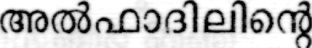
അല്‍ഫാദിലിന്റെ
